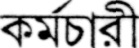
কর্মচারী
